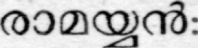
രാമയ്യന്‍:
